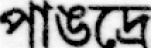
পাঙদ্রে
